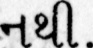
નથી.
